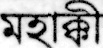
মহাক্কী
